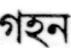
গহন
